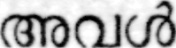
അവള്‍
